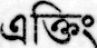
এক্তিং
